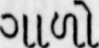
ગાળો
